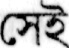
সেই
